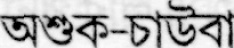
অশুক-চাউবা
